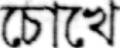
চোখে
